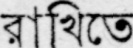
রাখিতে
